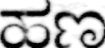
ಹಣ
